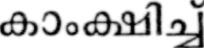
കാംക്ഷിച്ച്
